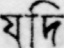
যদি
